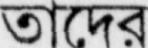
তাদের
